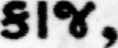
કાજ,
